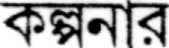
কল্পনার
